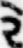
રે
